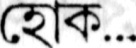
হোক..
